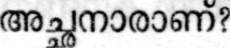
അച്ഛനാരാണ്?
